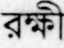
রক্ষী
